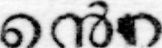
ന്റെ
